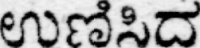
ಉಣಿಸಿದ
